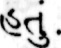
હતું.
